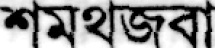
শমথজবা
